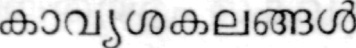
കാവ്യശകലങ്ങള്‍
